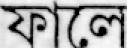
ফালে
